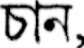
চান,
